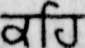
ਕਹਿ
